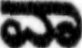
ವಾ
